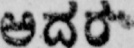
ಅದರ
